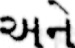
અને
